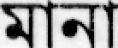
মানা
